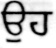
ਉਹ
